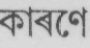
কাৰণে
